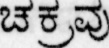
ಚಕ್ರವು
